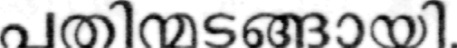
പതിന്മടങ്ങായി.
